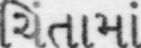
ચિંતામાં
